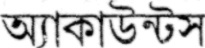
অ্যাকাউন্টস
